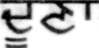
ਦੂਣਾ
